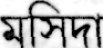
মসিদা
